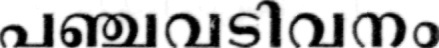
പഞ്ചവടിവനം
